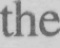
the
